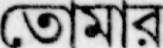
তোমার
